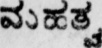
ಮಹತ್ವ
